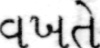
વખતે
